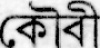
কৌবী
